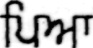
ਪਿਆ
